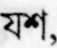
যশ,
